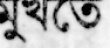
মুখতে
